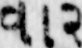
વાર
